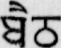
ਬੈਠ
